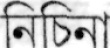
নিচিনা
